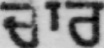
ਚਾਰ
